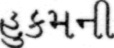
હુકમની
